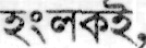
হংলকই,
